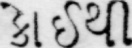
કોઈથી
